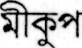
মীকুপ
